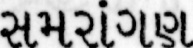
સમરાંગણ
